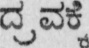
ದ್ರವಕ್ಕೆ
